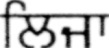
ਲਿਜਾ
